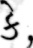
કે,
